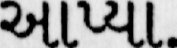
આપ્યા.
